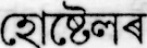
হোষ্টেলৰ
